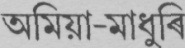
অমিয়া-মাধুৰি
